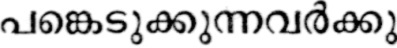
പങ്കെടുക്കുന്നവര്‍ക്കു
